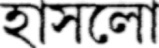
হাসলো
